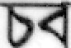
চব
